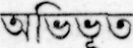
অভিভূত
